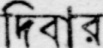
দিবার
